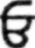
ਓ
